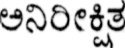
ಅನಿರೀಕ್ಷಿತ
